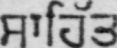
ਸਾਹਿੱਤ
